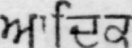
ਆਦਿਕ
